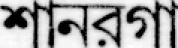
শানরগা
